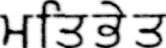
ਮਤਿਭੇਤ
